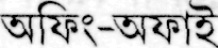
অফিং-অফাই
